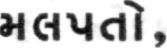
મલપતો,
